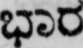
ಭಾರ
